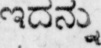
ಇದನ್ನು
